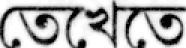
তেখেতে
